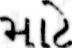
માટે
